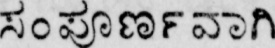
ಸಂಪೂರ್ಣವಾಗಿ
